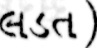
લડત)
